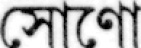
সোণো
